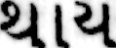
થાય
